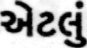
એટલું
